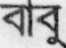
বাবু
